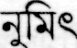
নুমিৎ
